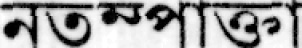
নতম্পাক্তা
